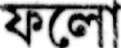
ফলো
